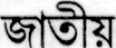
জাতীয়
